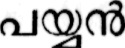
പയ്യന്‍
